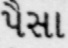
પૈસા
